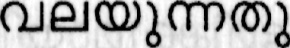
വലയുന്നതു
